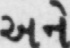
અને
